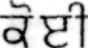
ਕੋਈ
